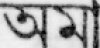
অমা
